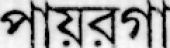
পায়রগা
